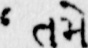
'તમે
